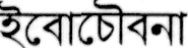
ইবোচৌবনা
